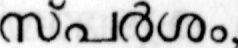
സ്പര്‍ശം,
